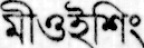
মীওইশিং
